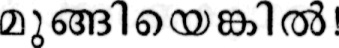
മുങ്ങിയെങ്കില്‍!
